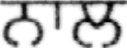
ਨਾਲ
